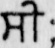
ਸੀ;
